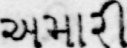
અમારી
